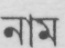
নাম
